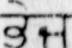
ਭੇਜ
